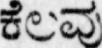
ಕೆಲವು
